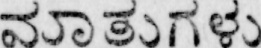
ಮಾತುಗಳು
